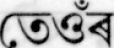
তেওঁৰ
